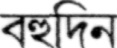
বহুদিন
